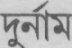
দুৰ্নাম
